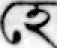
হে
